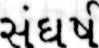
સંઘર્ષ
